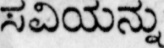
ಸವಿಯನ್ನು
